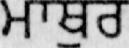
ਮਾਥੁਰ
